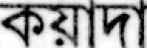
কয়াদা
